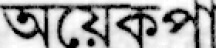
অয়েকপা
